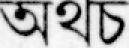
অথচ
